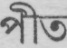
পীত
